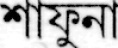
শাফুনা
